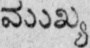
ಮುಖ್ಯ
